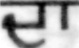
ਦਾ
